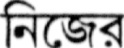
নিজের
